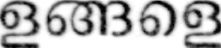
ളങ്ങളെ
